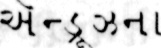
ઍન્ડ્રૂઝના
